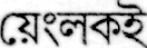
য়েংলকই
